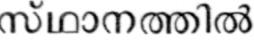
സ്ഥാനത്തില്‍
